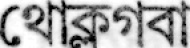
থোক্লগবা
